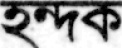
হন্দক
